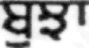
ਬੁਝਾ
